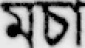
মচা
